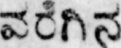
ವರೆಗಿನ
